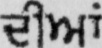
ਦੀਆਂ
